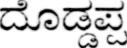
ದೊಡ್ಡಪ್ಪ
